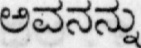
ಅವನನ್ನು
